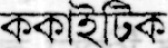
ককাইটিক
